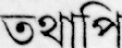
তথাপি
